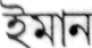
ইমান
